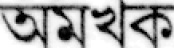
অমখক
